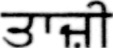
ਤਾਜ਼ੀ
